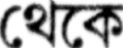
থেকে
